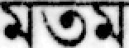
মতম
